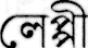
লেপ্পী
